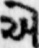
એ
